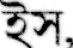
ইস,
